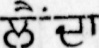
ਲੈਂਦਾ
